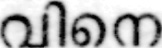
വിനെ
